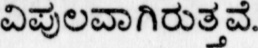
ವಿಪುಲವಾಗಿರುತ್ತವೆ.
